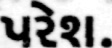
પરેશ.
